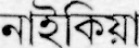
নাইকিয়া
